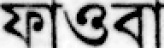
ফাওবা
